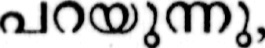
പറയുന്നു,
